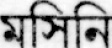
মসিনি
